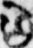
છે
